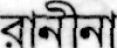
রানীনা
